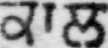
ਕਾਲ
